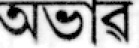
অভাৱ
